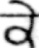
ਕੇ
